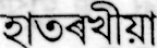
হাতৰখীয়া
